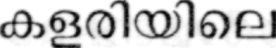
കളരിയിലെ
